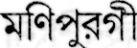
মণিপুরগী
